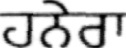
ਹਨੇਰਾ
